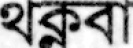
থক্নবা
